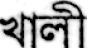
খালী
